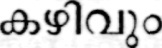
കഴിവും
